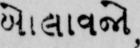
બોલાવજો.
